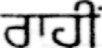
ਰਾਹੀਂ
